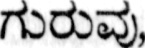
ಗುರುವು,
